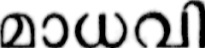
മാധവി
